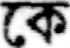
কে
